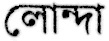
লোন্দা
